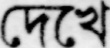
দেখে
